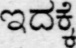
ಇದಕ್ಕೆ
